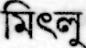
মিৎলু
